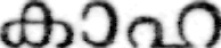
കാഹ
